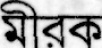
মীরক
